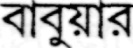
বাবুয়ার
